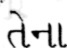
તેના
